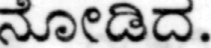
ನೋಡಿದ.
